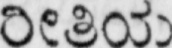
ರೀತಿಯ
